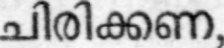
ചിരിക്കണ,
